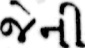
જેની
